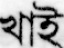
খাই
